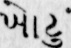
ખોટું
